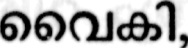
വൈകി,
